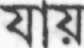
যায়
